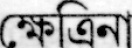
ক্ষেত্রিনা
